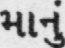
માનું
